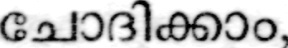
ചോദിക്കാം,
